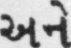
અને
